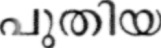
പുതിയ
